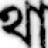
থা
